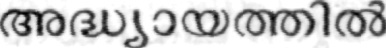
അദ്ധ്യായത്തില്‍
